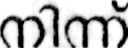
നിന്ന്
